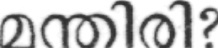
മന്തിരി?
